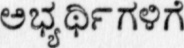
ಅಭ್ಯರ್ಥಿಗಳಿಗೆ
